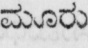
ಮೂರು
